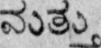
ಮತ್ತು
